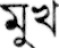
মুখ
